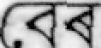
বেৰ
